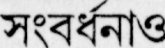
সংবর্ধনাও
